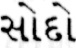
સોદો
